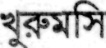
খুরুমসি
